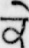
ਕੇ
